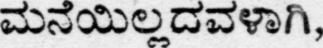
ಮನೆಯಿಲ್ಲದವಳಾಗಿ,
